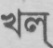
খল্
